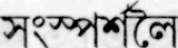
সংস্পৰ্শলৈ
